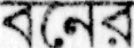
বনের
